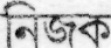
নিজক
